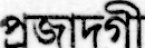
প্রজাদগী
